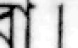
বা।
